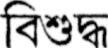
বিশুদ্ধ
